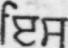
ਇਸ
